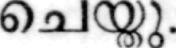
ചെയ്തു.
